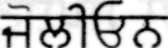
ਜੋਲੀਓਨ
